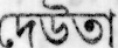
দেউতা
